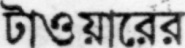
টাওয়ারের
